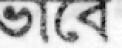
ভাবে
